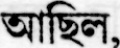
আছিল,
